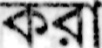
করা
